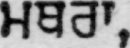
ਮਥਰਾ,
